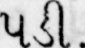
પડી.
